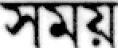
সময়
